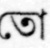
তো
